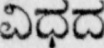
ವಿಧದ
